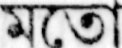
মতো
